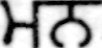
ਮਨ
